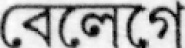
বেলেগে
